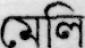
মেলি
